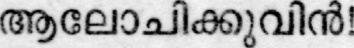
ആലോചിക്കുവിന്‍!
